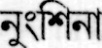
নুংশিনা
